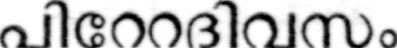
പിറേറദിവസം
